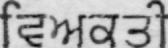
ਵਿਅਕਤੀ
